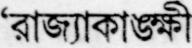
‘রাজ্যাকাঙ্ক্ষী
